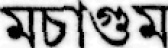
মচাগুম
